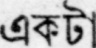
একটা
